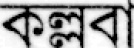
কল্লবা
